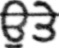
ਉਤੇ
